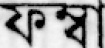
ফম্বা
